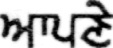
ਆਪਣੇ
